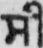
ਸੀ
